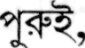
পুরুই,
